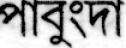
পাবুংদা
